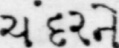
ચંદરને
